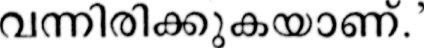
വന്നിരിക്കുകയാണ്.’
